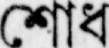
শোধ
